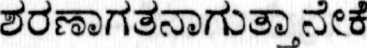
ಶರಣಾಗತನಾಗುತ್ತಾನೇಕೆ
